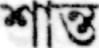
শান্ত
